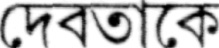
দেবতাকে
